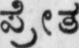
ಪ್ರೇತ
